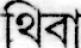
থিবা
